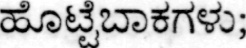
ಹೊಟ್ಟೆಬಾಕಗಳು;
